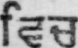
ਵਿਚ
